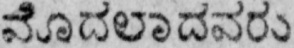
ಮೊದಲಾದವರು
